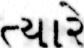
ત્યારે
